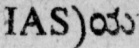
IAS)ಯ
